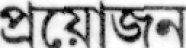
প্রয়োজন
